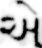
એ
